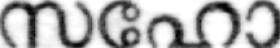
സഹോ
